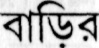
বাড়ির
